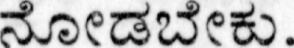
ನೋಡಬೇಕು.
